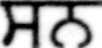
ਸਨ
